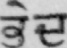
ਭੇਦ
